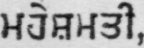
ਮਹੇਸ਼ਮਤੀ,
